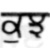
ਕੁਝ
